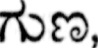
ಗುಣ,
